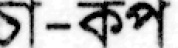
চা-কপ
